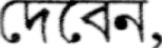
দেবেন,
